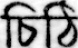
চিঠি
